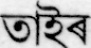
তাইৰ
